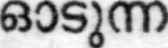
ഓടുന്ന
